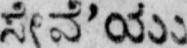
ಸೇವೆ’ಯು
